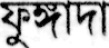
ফুঙ্গাদা
